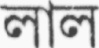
লাল
